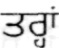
ਤਰ੍ਹਾਂ
